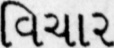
વિચાર
